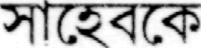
সাহেবকে
